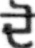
ਦੋ
